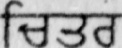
ਚਿਤਰ
